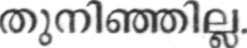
തുനിഞ്ഞില്ല.
